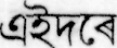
এইদৰে
